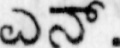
ಎನ್.
